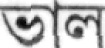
ভাল
